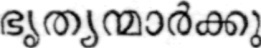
ഭൃത്യന്മാര്‍ക്കു
